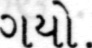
ગયો.
